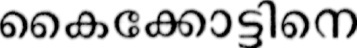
കൈക്കോട്ടിനെ
